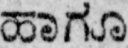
ಹಾಗೂ
